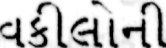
વકીલોની
